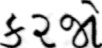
કરજો
